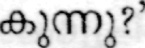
കുന്നു?’
